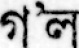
গ'ল
